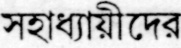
সহাধ্যায়ীদের
